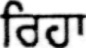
ਰਿਹਾ
